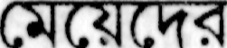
মেয়েদের
